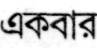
একবার
